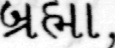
બ્રહ્મા,
